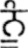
ਨੂੰ
